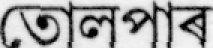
তোলপাৰ
